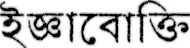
ইজ্ঞাবোক্তি
